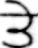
ਤੇ
